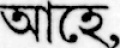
আহে,
